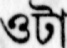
ওটা
